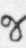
જ
